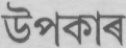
উপকাৰ
